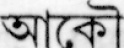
আকৌ
